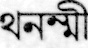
থনম্মী
